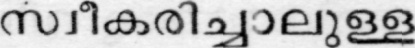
സ്വീകരിച്ചാലുള്ള
